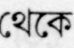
থেকে
